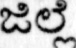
ಜಿಲ್ಲೆ
